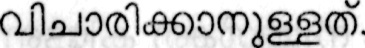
വിചാരിക്കാനുള്ളത്.
